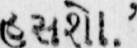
હસશો.'
